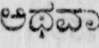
ಅಥವಾ
